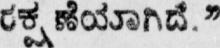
ರಕ್ಷಣೆಯಾಗಿದೆ.”
